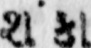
શંકા
